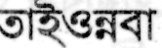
তাইওন্নবা
